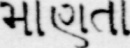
માણતા
